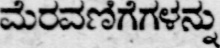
ಮೆರವಣಿಗೆಗಳನ್ನು
